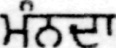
ਮੰਨਦਾ
